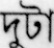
দুটা
